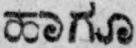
ಹಾಗೂ
